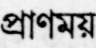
প্রাণময়
